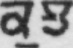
ਕੁਝ
